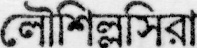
লৌশিল্লসিরা
